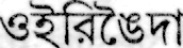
ওইরিঙৈদা
